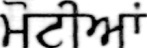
ਮੋਟੀਆਂ
